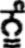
ਨੂੰ
